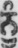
ਨੂੰ
